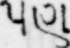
પણ
